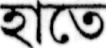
হাতে
